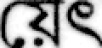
য়েং
